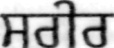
ਸਰੀਰ
